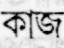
কাজ
